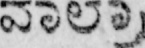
ವಾಲ್ರಾ
